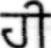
ਹੀ
